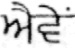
ਐਵੇਂ
